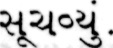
સૂચવ્યું.
